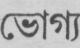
ভোগ্য
